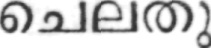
ചെലതു
